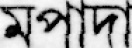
মপাদা
